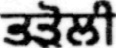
ਭੜੋਲੀ
